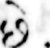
છે.
